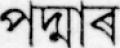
পদ্মাৰ
